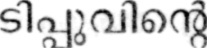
ടിപ്പുവിന്റെ
